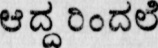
ಆದ್ದರಿಂದಲೆ
